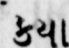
ક્યા
